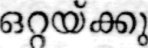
ഒറ്റയ്ക്കു
